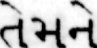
તેમને
